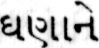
ઘણાને
